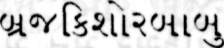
બ્રજકિશોરબાબુ
